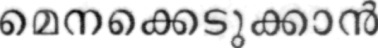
മെനക്കെടുക്കാന്‍
